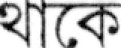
থাকে
